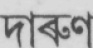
দাৰুণ
